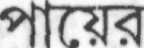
পায়ের
